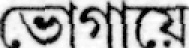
ভোগায়ে
